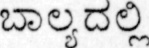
ಬಾಲ್ಯದಲ್ಲಿ
